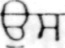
ਉਸ
